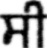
ਸੀ
